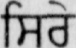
ਸਿਰੇ
